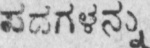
ಪದಗಳನ್ನು
